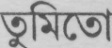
তুমিতো
